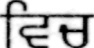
ਵਿਚ
